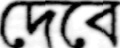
দেবে
